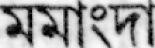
মমাংদা
